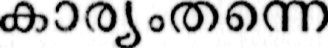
കാര്യംതന്നെ
